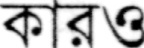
কারও
